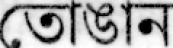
তোঙান
